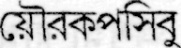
য়ৌরকপসিবু
